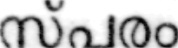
സ്പരം
